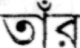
তাঁর
